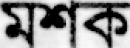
মশক
